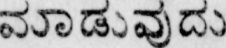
ಮಾಡುವುದು
